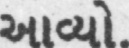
આવ્યો.
